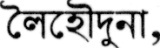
লৈহৌদুনা,
